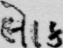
લોક
